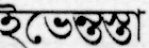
ইভেন্তস্তা
